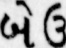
બેઉ
